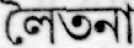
লৈতনা
